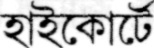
হাইকোর্টে
